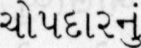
ચોપદારનું
